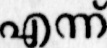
എന്ന്
